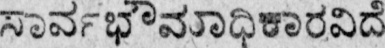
ಸಾರ್ವಭೌಮಾಧಿಕಾರವಿದೆ
